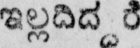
ಇಲ್ಲದಿದ್ದರೆ
